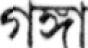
গঙ্গা
